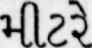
મીટરે
